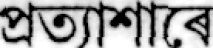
প্রত্যাশাৰে
